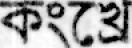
কংখ্রে
